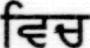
ਵਿਚ
